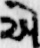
એ
